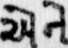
એને
